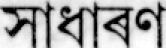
সাধাৰণ
